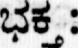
ಭಕ್ತ:
